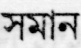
সমান
